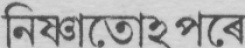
নিষ্ণাতোহপৰে
